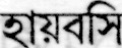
হায়বসি
